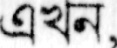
এখন,
